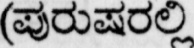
(ಪುರುಷರಲ್ಲಿ
